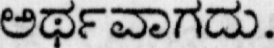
ಅರ್ಥವಾಗದು.
